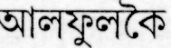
আলফুলকৈ
